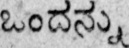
ಒಂದನ್ನು
